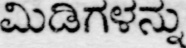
ಮಿಡಿಗಳನ್ನು
